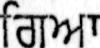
ਗਿਆ
